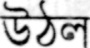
উঠল
